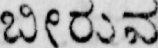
ಬೀರುವ
